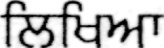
ਲਿਖਿਆ
